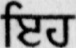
ਇਹ
